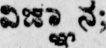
ವಿಜ್ಞಾನ;
